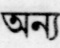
অন্য
